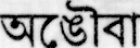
অঙৌবা
